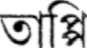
তাপ্পি
